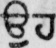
ਉਹ
